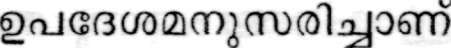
ഉപദേശമനുസരിച്ചാണ്
